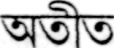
অতীত
